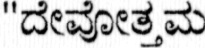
“ದೇವೋತ್ತಮ
